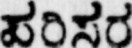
ಪರಿಸರ
